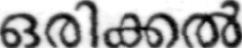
ഒരിക്കല്‍
